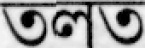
তলত
